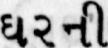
ઘરની
